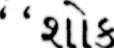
"શોક
